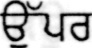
ਉੱਪਰ
